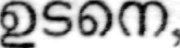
ഉടനെ,
